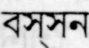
বস্সন
